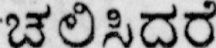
ಚಲಿಸಿದರೆ
